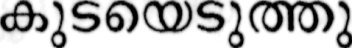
കുടയെടുത്തു
